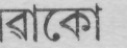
সৱাকো
